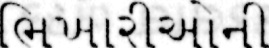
ભિખારીઓની
